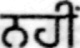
ਨਹੀਂ
